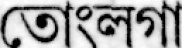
তোংলগা
